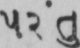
પરંતુ
